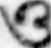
ও
